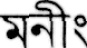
মনীং
